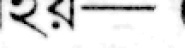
হয়-
